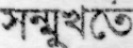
সন্মুখতে
